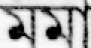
মমা
